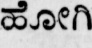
ಹೋಗಿ
